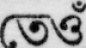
তেওঁ
